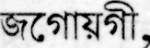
জগোয়গী,
